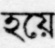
হয়ে
